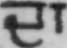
ਦਾ
